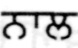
ਨਾਲ
